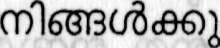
നിങ്ങള്‍ക്കു
